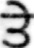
ਤੇ
